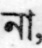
না,
